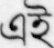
এই
